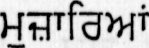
ਮੁਜ਼ਾਰਿਆਂ
